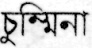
চুম্মিনা
